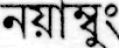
নয়াম্বুং
